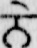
ਨੇ
